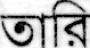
তারি
